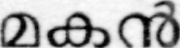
മകന്‍
